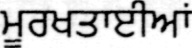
ਮੂਰਖਤਾਈਆਂ
